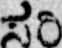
ಸರಿ
